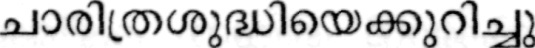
ചാരിത്രശുദ്ധിയെക്കുറിച്ചു
